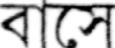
বাসে
